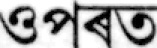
ওপৰত
